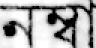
নম্বা
